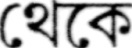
থেকে
